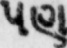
પણ
